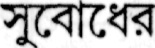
সুবোধের
